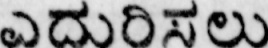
ಎದುರಿಸಲು
